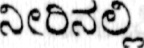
ನೀರಿನಲ್ಲಿ
